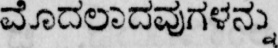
ಮೊದಲಾದವುಗಳನ್ನು
